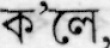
ক'লে,
